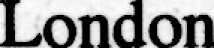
London
